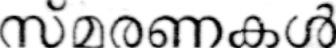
സ്മരണകള്‍
